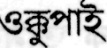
ওক্কুপাই
